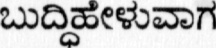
ಬುದ್ಧಿಹೇಳುವಾಗ
